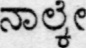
ನಾಲ್ಕೇ
